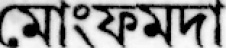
মোংফমদা
